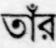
তাঁর
